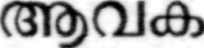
ആവക
